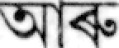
আৰু
